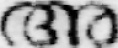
അ
